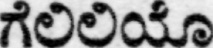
ಗೆಲಿಲಿಯೊ
